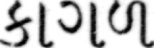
કાગળ
